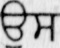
ਉਸ
